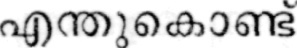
എന്തുകൊണ്ട്
